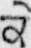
ਕੇ
